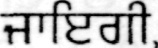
ਜਾਇਗੀ,
